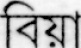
বিয়া
